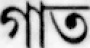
গাত
